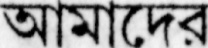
আমাদের
